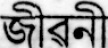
জীৱনী
